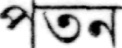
পতন
